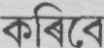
কৰিবে
